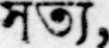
সত্য,
